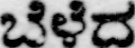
ಬೆಳೆದ
